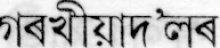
গৰখীয়াদ'লৰ
